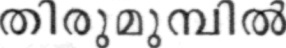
തിരുമുമ്പില്‍
